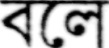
বলে
